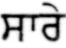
ਸਾਰੇ
